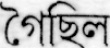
গৈছিল
